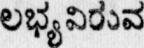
ಲಭ್ಯವಿರುವ
